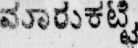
ಮಾರುಕಟ್ಟೆ
